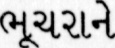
ભૂચરાને
